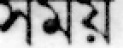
সময়
